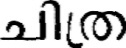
ചിത്ര
